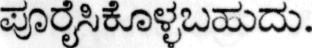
ಪೂರೈಸಿಕೊಳ್ಳಬಹುದು.
